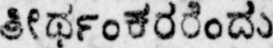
ತೀರ್ಥಂಕರರೆಂದು
